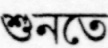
শুনতে
